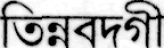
তিন্নবদগী
